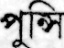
পুন্সি
